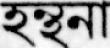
হন্থনা
